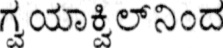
ಗ್ವಯಾಕ್ವಿಲ್ನಿಂದ
